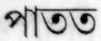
পাতত
